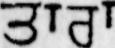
ਤਾਰਾ
